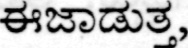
ಈಜಾಡುತ್ತ,
